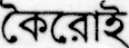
কৈরোই
